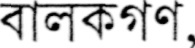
বালকগণ,
